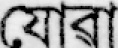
যোৱা
